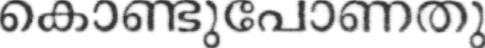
കൊണ്ടുപോണതു
